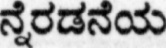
ನ್ನೆರಡನೆಯ
